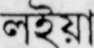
লইয়া
